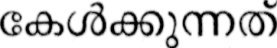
കേള്‍ക്കുന്നത്
